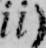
ii)
